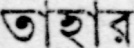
তাহার
